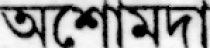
অশোমদা
